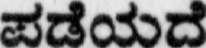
ಪಡೆಯದೆ
